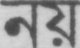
নয়
